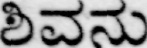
ಶಿವನು
